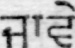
ਜਾਵੇ
